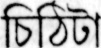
চিঠিটা
